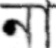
না
